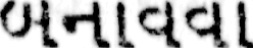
બનાવવા
